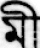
মী
